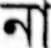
না
